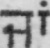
ਜਾਂ
